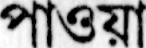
পাওয়া
